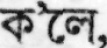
ক'লে,
